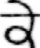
ਕੇ
